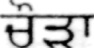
ਚੌੜਾ
